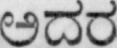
ಅದರ
